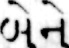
બેને
